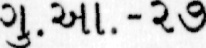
ગુ.આ.-૨૭
